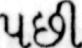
પછી
